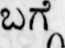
ಬಗ್ಗೆ
